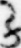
કે
